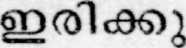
ഇരിക്കു
